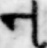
ન
